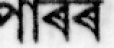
পাৰৰ
